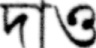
দাও
